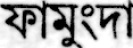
ফামুংদা
